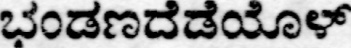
ಭಂಡಣದೆಡೆಯೊಳ್
